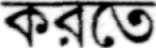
করতে
